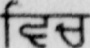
ਵਿਚ
